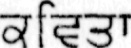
ਕਵਿਤਾ
